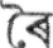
ৰৈ
